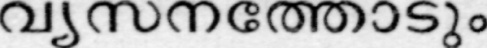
വ്യസനത്തോടും
